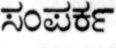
ಸಂಪರ್ಕ
